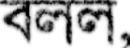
বলল,
